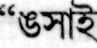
“ঙসাই
